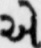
એ
